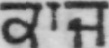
ਕਾਜ
